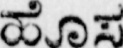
ಹೊಸ
